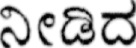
ನೀಡಿದ
